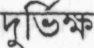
দুর্ভিক্ষ
